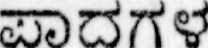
ಪಾದಗಳ
